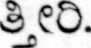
ತ್ತೀರಿ.
